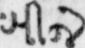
બીજે
